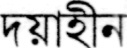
দয়াহীন
